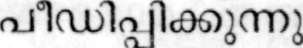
പീഡിപ്പിക്കുന്നു
